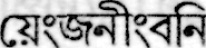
য়েংজনীংবনি
